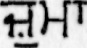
ਜ਼ੁਮਾ
